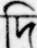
দি
